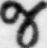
જ
